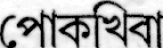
পোকখিবা
